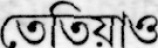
তেতিয়াও
